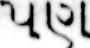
પણ
